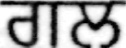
ਗਲ
